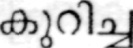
കുറിച്ച
